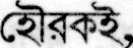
হৌরকই,
